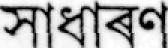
সাধাৰণ
